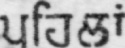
ਪਹਿਲਾਂ
